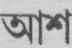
আশ
